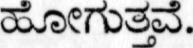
ಹೋಗುತ್ತವೆ.
